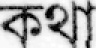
কথা
